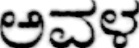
ಅವಳ
